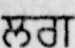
ਲਗ
